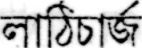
লাঠিচার্জ
